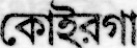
কোইরগা
